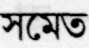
সমেত
